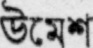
উমেশ
